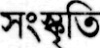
সংস্কৃতি
